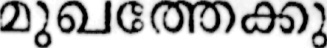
മുഖത്തേക്കു
